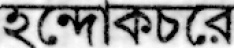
হন্দোকচরে
